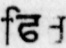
ਫਿਰ
